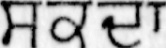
ਸਕਦਾ
